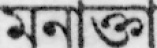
মনাক্তা
